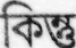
কিন্তু
